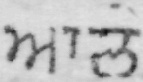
ਆਲੇ
